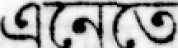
এনেতে
